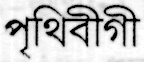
পৃথিবীগী
